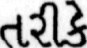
તરીકે
